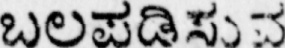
ಬಲಪಡಿಸುವ
